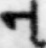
ન
